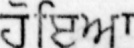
ਹੋਇਆ
